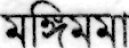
মঙ্গিমমা
